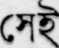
সেই
